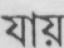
যায়
